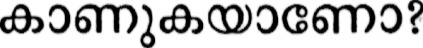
കാണുകയാണോ?
